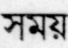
সময়
